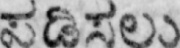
ಪಡಿಸಲು
